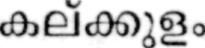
കല്ക്കുളം
